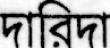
দারিদা
